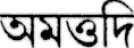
অমত্তদি
